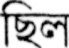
ছিল
